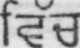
ਵਿੱਚ
